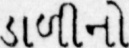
ડાળીનો
